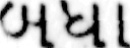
બધા
